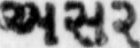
અસર
